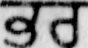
ਭਰ
